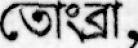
তোংব্রা,
